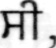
ਸੀ,
